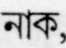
নাক,
